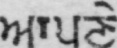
ਆਪਣੇ
